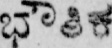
ಭೌತಿಕ
